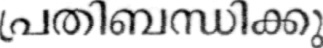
പ്രതിബന്ധിക്കു
